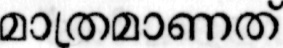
മാത്രമാണത്
